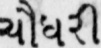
ચૌધરી
